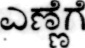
ಎಣ್ಣೆಗೆ
